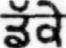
ਡੱਕੇ
